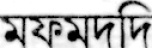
মফমদদি
